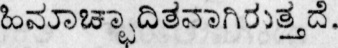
ಹಿಮಾಚ್ಛಾದಿತವಾಗಿರುತ್ತದೆ.
